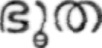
ഭൂത
